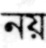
নয়
